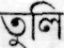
তুলি
